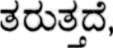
ತರುತ್ತದೆ,
